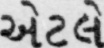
એટલે
